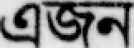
এজন
